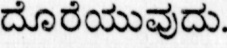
ದೊರೆಯುವುದು.
